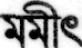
মমীৎ
